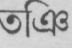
তঞি
